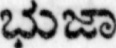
ಭುಜಾ
